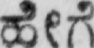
ಹೇಗೆ
